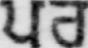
ਪਰ
